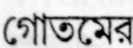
গোতমের
